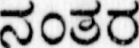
ನಂತರ
